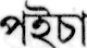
পইচা
